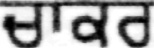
ਚਾਕਰ
